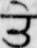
ਤੇ
